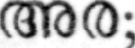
അര;
